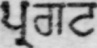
ਪ੍ਰਗਟ
